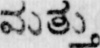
ಮತ್ತು
